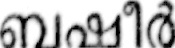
ബഷീര്‍
